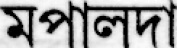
মপালদা
